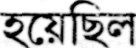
হয়েছিল
